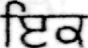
ਇਕ
